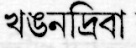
খঙনদ্রিবা
